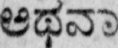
ಅಥವಾ
